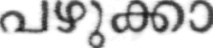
പഴുക്കാ
